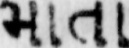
માતા
